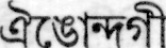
ঐঙোন্দগী
